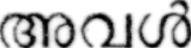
അവള്‍
